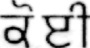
ਕੋਈ
